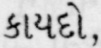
કાયદો,
